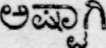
ಅಷ್ಟಾಗಿ
